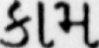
કામ
